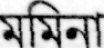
মমিনা
